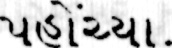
પહોંચ્યા.
